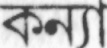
কন্যা
